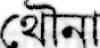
থৌনা
